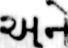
અને
